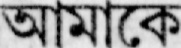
আমাকে
